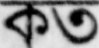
কত
